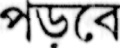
পড়বে
